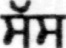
ਸੱਸ
